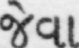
જેવા
